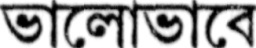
ভালোভাবে
